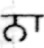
ਨਾ
